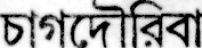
চাগদৌরিবা
